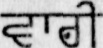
ਵਾਰੀ
